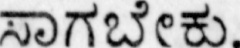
ಸಾಗಬೇಕು.
